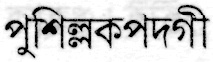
পুশিল্লকপদগী
